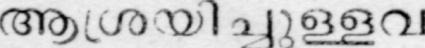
ആശ്രയിച്ചുള്ളവ
